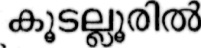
കൂടല്ലൂരില്‍
